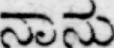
ನಾನು
